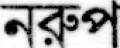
নরুপ
